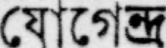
যোগেন্দ্র
